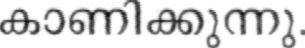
കാണിക്കുന്നു.
